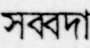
সব্বদা
